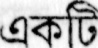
একটি
